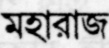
মহারাজ
